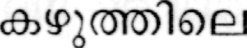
കഴുത്തിലെ
